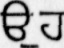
ਉਹ
